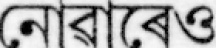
নোৱাৰেও
